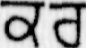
ਕਰ
